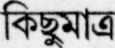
কিছুমাত্র
